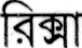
রিক্সা
